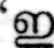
‘ഇ
